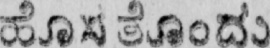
ಹೊಸತೊಂದು
